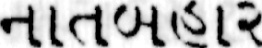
નાતબહાર
